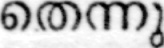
തെന്നു
